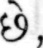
છે,
